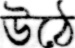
উঠে
